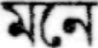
মনে
